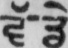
ਵੱਡੇ
